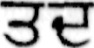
ਤਦ
